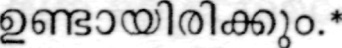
ഉണ്ടായിരിക്കും.*
